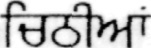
ਚਿਠੀਆਂ
